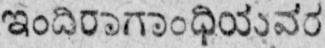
ಇಂದಿರಾಗಾಂಧಿಯವರ
